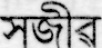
সজীৱ
